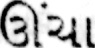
ઊંચા
